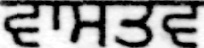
ਵਾਸਤਵ
